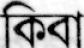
কিবা
